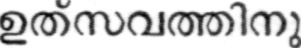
ഉത്സവത്തിനു
